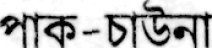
পাক-চাউনা
